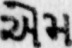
એમ
